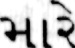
મારે
